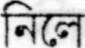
নিলে
